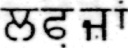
ਲਫ਼ਜ਼ਾਂ
